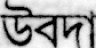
উবদা
